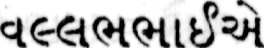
વલ્લભભાઈએ
